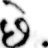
છે.
